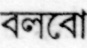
বলবো
